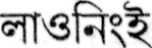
লাওনিংই
